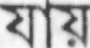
যায়
